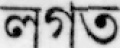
লগত
